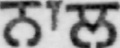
ਨਾਲ
